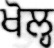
ਖੋਲ੍ਹ
